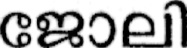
ജോലി
